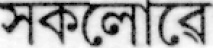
সকলোৱে
